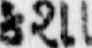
કશા
